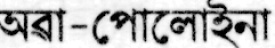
অৱা-পোলোইনা
